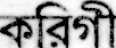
করিগী
